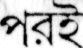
পরই
